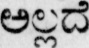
ಅಲ್ಲದೆ
